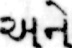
અને
